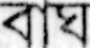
বাঘ
